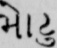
મોટુ
